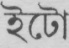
ইটো
